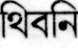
থিবনি
